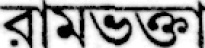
রামঙক্তা
